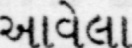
આવેલા
